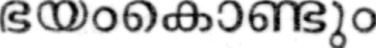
ഭയംകൊണ്ടും
